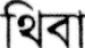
থিবা
